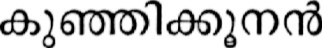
കുഞ്ഞിക്കൂനന്‍
